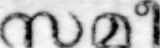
സമീ
